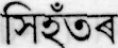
সিহঁতৰ
